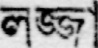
লজ্জা
